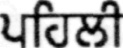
ਪਹਿਲੀ
